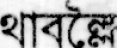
থবল্লৈ
